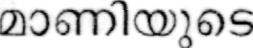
മാണിയുടെ
